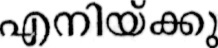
എനിയ്ക്കു
